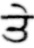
ਤੇ
